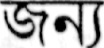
জন্য
